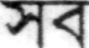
সব
